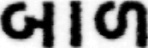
બાળ
